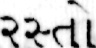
રસ્તો
